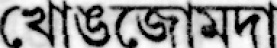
খোঙজোমদা
